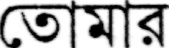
তোমার
